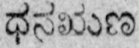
ಧನಋಣ
